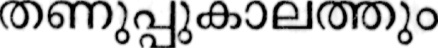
തണുപ്പുകാലത്തും
